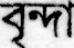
বৃন্দা
